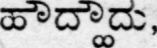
ಹೌದ್ಹೌದು,
